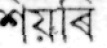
শিয়ৰি
